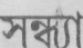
সন্ধ্যা
